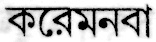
করেমনবা
